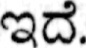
ಇದೆ.
